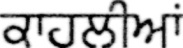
ਕਾਹਲੀਆਂ
